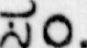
ಸಂ.
